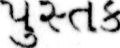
પુસ્તક
